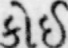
કોઈ
